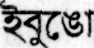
ইবুঙো
